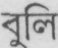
বুলি
